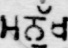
ਮਨੁੱਖ
